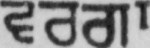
ਵਰਗਾ
